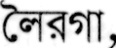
লৈরগা,
